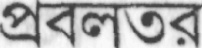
প্রবলতর
